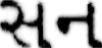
સન
